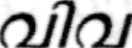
വിവ
